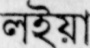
লইয়া
